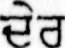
ਦੇਰ
